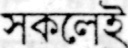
সকলেই
